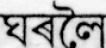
ঘৰলৈ
